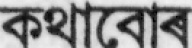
কথাবোৰ
